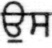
ਉਸ
